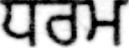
ਧਰਮ
